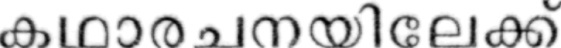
കഥാരചനയിലേക്ക്
